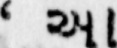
'આ
